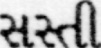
સસ્તી
